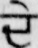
ਦੇ
